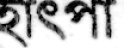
হাৎপা
